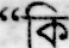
"কি
